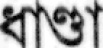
ধাণ্ডা
